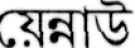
য়েন্নাউ
